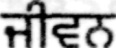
ਜੀਵਨ
